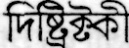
দিষ্ট্রিক্টকী
